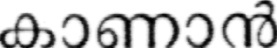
കാണാന്‍
